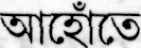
আহোঁতে
